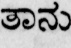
ತಾನು
